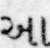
આ
